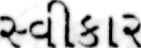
સ્વીકાર
